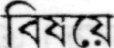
বিষয়ে
